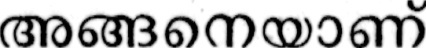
അങ്ങനെയാണ്
